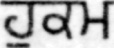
ਹੁਕਮ
